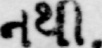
નથી.
